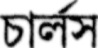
চার্লস
